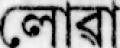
লোৱা
